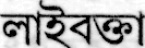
লাইবক্তা
